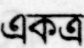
একত্র
